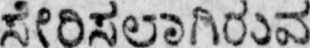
ಸೇರಿಸಲಾಗಿರುವ
